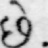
છે.
